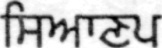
ਸਿਆਣਪ
